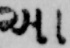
આ
